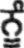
ਨੂੰ
